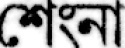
শেংনা
